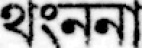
থংননা
